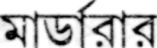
মার্ডারার
